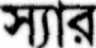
স্যার
